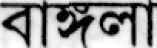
বাঙ্গলা
